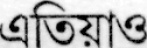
এতিয়াও
